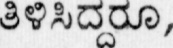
ತಿಳಿಸಿದ್ದರೂ,
